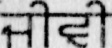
ਜੀਵੀ
